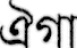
ঐগা
